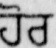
ਹੋਰ
